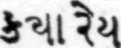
ક્યારેય
